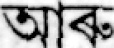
আৰু
